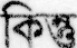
কিন্তু
